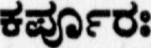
ಕರ್ಪೂರಃ
